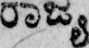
ರಾಜ್ಯ
